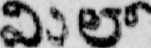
ಮಿಲ್
